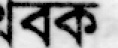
থবক
